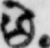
છે.
